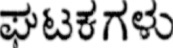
ಘಟಕಗಳು
